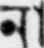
না
